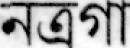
নত্রগা
